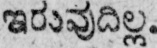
ಇರುವುದಿಲ್ಲ.
